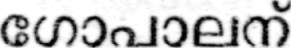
ഗോപാലന്
